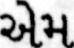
એમ
